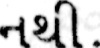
નથી.
